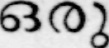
ഒരു
